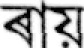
ৰায়
